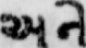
અને
